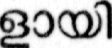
ളായി
